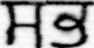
ਸਭ
